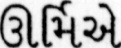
ઊર્મિએ
